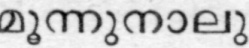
മൂന്നുനാലു
